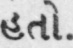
હતો.
